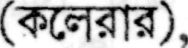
(কলেরার),
